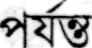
পর্যন্ত
